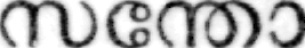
സന്തോ
